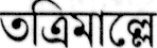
তত্রিমাল্লে
